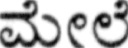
ಮೇಲೆ
